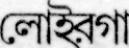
লোইরগা
